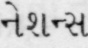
નેશન્સ
